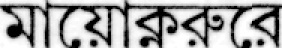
মায়োক্নরুরে
